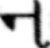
ન
